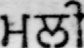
ਮਲੀ
